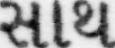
સાથ
